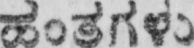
ಹಂತಗಳು
